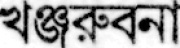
খঞ্জরুবনা
